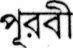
পূরবী
